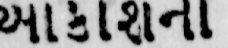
આકાશના
